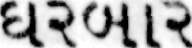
ઘરબાર
